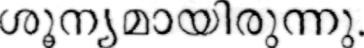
ശൂന്യമായിരുന്നു.
